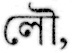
লৌ,
